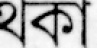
থকা
